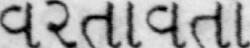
વરતાવતા
